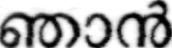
ഞാന്‍
